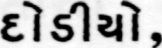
દોડીયો,
